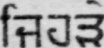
ਜਿਹੜੇ
